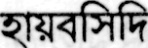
হায়বসিদি
